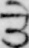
ਤੇ
